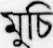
মুচি
